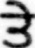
ਤੇ
